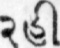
રહી
